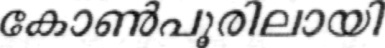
കോണ്‍പൂരിലായി
